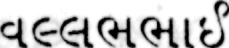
વલ્લભભાઈ
